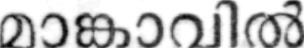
മാങ്കാവില്‍
